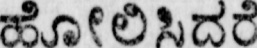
ಹೋಲಿಸಿದರೆ
